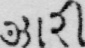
ઝારી
